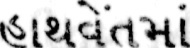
હાથવેંતમાં
